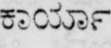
ಕಾರ್ಯಾ
